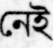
নেই
